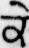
ਕੇ
